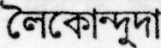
লৈকোন্দুদা
